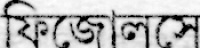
ফিজোলসে
